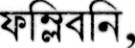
ফম্লিবনি,
